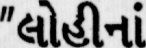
"લોહીનાં
